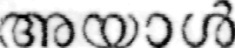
അയാള്‍
